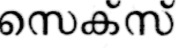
സെക്സ്
